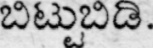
ಬಿಟ್ಟುಬಿಡಿ.
